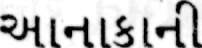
આનાકાની
